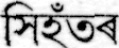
সিহঁতৰ
